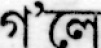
গ'লে
